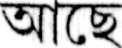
আছে
